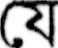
যে
